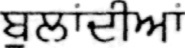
ਬੁਲਾਂਦੀਆਂ
